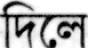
দিলে
